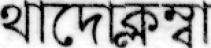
থাদোক্লম্বা
